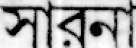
সারনা
